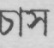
চাস
